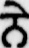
ਨੇ
